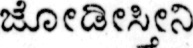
ಜೋಡೀಸ್ತೀನಿ
